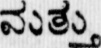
ಮತ್ತು
